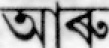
আৰু
